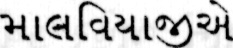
માલવિયાજીએ
